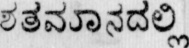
ಶತಮಾನದಲ್ಲಿ
